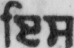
ਇਸ
